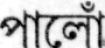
পালোঁ
